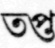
তপ্ত
